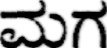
ಮಗ
